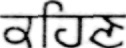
ਕਹਿਣ
